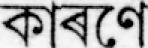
কাৰণে
